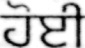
ਹੋਈ
